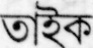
তাইক
